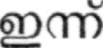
ഇന്ന്
